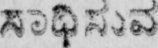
ಸಾಧಿಸುವ
